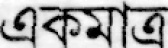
একমাত্র
